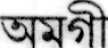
অমগী
